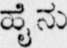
ಹೈನು
